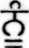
ਨੂੰ
